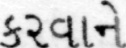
કરવાને
